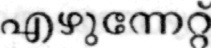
എഴുന്നേറ്റ്
